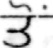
ਤੋਂ
